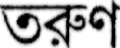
তরুণ
